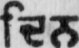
ਦਿਨ
